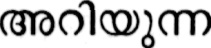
അറിയുന്ന
